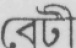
বেটী
